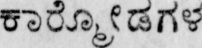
ಕಾರ್‍ಮೋಡಗಳ
